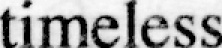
timeless
